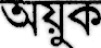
অয়ুক
